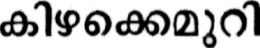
കിഴക്കെമുറി
